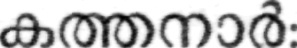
കത്തനാര്‍:
